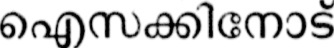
ഐസക്കിനോട്
